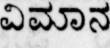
ವಿಮಾನ
